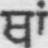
ਥਾਂ
